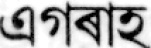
এগৰাহ
